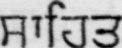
ਸਾਹਿਤ
